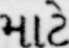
માટે
